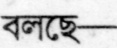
বলছে–
